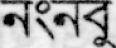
নংনবু
